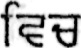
ਵਿਚ
